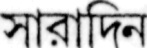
সারাদিন
